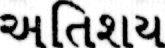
અતિશય
